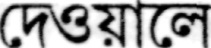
দেওয়ালে
